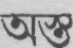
অস্ত
